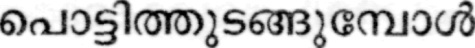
പൊട്ടിത്തുടങ്ങുമ്പോള്‍
